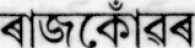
ৰাজকোঁৱৰ
